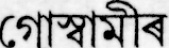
গোস্বামীৰ
